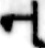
ન
